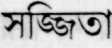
সজ্জিতা
